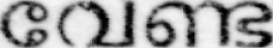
വേണ്ട
